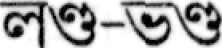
লণ্ড-ভণ্ড
